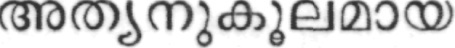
അത്യനുകൂലമായ
